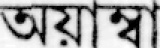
অয়াম্বা
